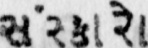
સંસ્કારો
